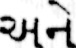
અને
